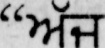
''ਅੱਜ
